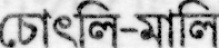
চোৎলি-মালি
